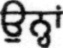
ਉਨ੍ਹਾਂ
